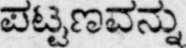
ಪಟ್ಟಣವನ್ನು
